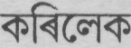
কৰিলেক
